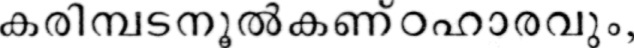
കരിമ്പടനൂല്‍കണ്ഠഹാരവും,
